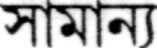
সামান্য
